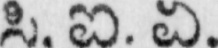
ಸಿ.ಐ.ಏ.
